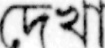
দেখা
